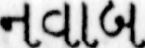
નવાબ
